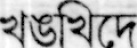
খঙখিদে
